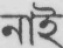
নাই
